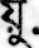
য়ু.
